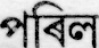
পৰিল
